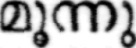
മൂന്നു
